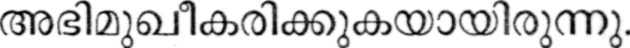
അഭിമുഖീകരിക്കുകയായിരുന്നു.
